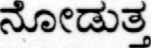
ನೋಡುತ್ತ
